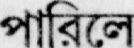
পারিলে
